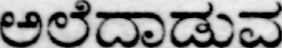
ಅಲೆದಾಡುವ
